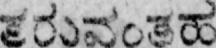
ತರುವಂತಹ
